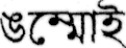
ঙম্মোই
